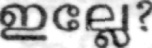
ഇല്ലേ?
